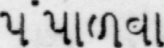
પંપાળવા
